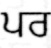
ਪਰ
